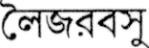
লৈজরবসু
